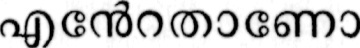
എന്റേതാണോ
